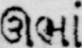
ઊભાં
